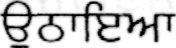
ਉਠਾਇਆ
